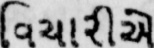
વિચારીએ
